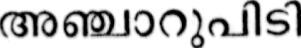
അഞ്ചാറുപിടി
